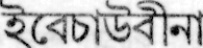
ইবেচাউবীনা
